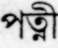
পত্নী
